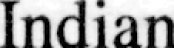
Indian
